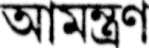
আমন্ত্রণ
